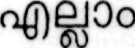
എല്ലാം
